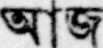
আজ
